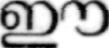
ഈ
